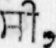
ਸੀ,
